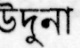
উদুনা
